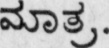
ಮಾತ್ರ.
